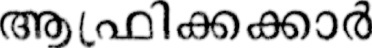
ആഫ്രിക്കക്കാര്‍
